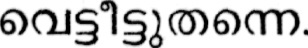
വെട്ടീട്ടുതന്നെ.
